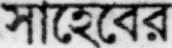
সাহেবের
